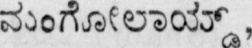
ಮಂಗೋಲಾಯ್ಡ್,
